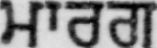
ਮਾਰਗ
